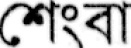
শেংবা
